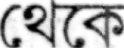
থেকে
